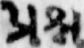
પ્રશ્ન
